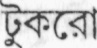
টুকরো
